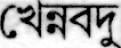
খেন্নবদু
